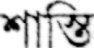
শাস্তি
